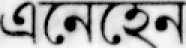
এনেহেন
